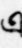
এ
